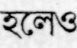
হলেও
